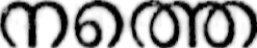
നത്തെ
